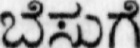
ಬೆಸುಗೆ
